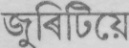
জুৰিটিয়ে
